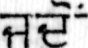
ਜਦੋਂ
